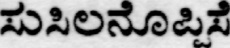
ಸುಸಿಲನೊಪ್ಪಿಸೆ
